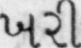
ખરી
